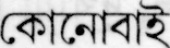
কোনোবাই
